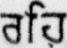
ਰਹਿ
